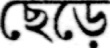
ছেড়ে
